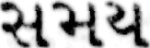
સમય
